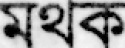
মথক
